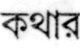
কথার
